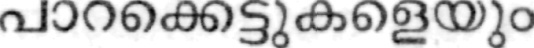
പാറക്കെട്ടുകളെയും
